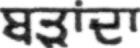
ਬੜਾਂਦਾ
